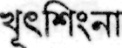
খূৎশিংনা
